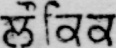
ਲੌਕਿਕ
